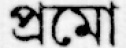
প্রমো
